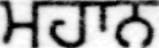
ਮਹਾਨ
